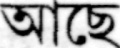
আছে
